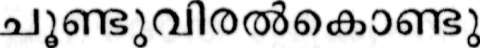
ചൂണ്ടുവിരല്‍കൊണ്ടു
